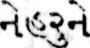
નેહરુને
